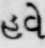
હવે
